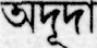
অদূদা
